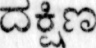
ದಕ್ಷಿಣ
